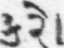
કરો
